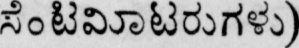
ಸೆಂಟಿಮೀಟರುಗಳು)
